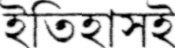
ইতিহাসই
